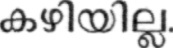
കഴിയില്ല.
